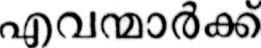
എവന്മാര്‍ക്ക്
